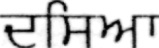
ਦਸਿਆ
